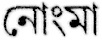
নোংমা
